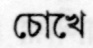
চোখে
